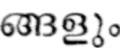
ങ്ങളും
